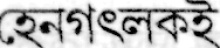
হেনগৎলকই
